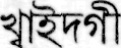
খ্বাইদগী
